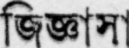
জিজ্ঞাসা
